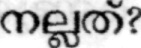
നല്ലത്?
